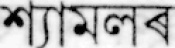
শ্যামলৰ
